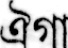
ঐগা
